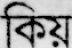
কিয়
